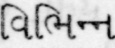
વિભિન્ન
